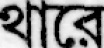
থারে
